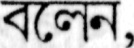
বলেন,
